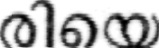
രിയെ
